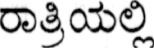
ರಾತ್ರಿಯಲ್ಲಿ
